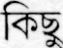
কিছু
